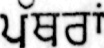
ਪੱਥਰਾਂ
